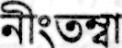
নীংতম্বা
